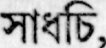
সাধচি,
